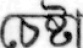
চেষ্টা
